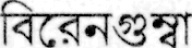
বিরেনগুম্বা
